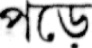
পড়ে
